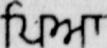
ਪਿਆ
